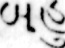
બહુ
